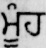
ਮੂੰਹ
